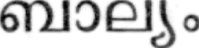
ബാല്യം
